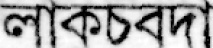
লাকচবদা
